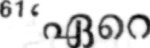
61'ഏറെ
